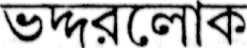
ভদ্দরলোক
